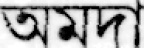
অমদা
